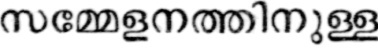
സമ്മേളനത്തിനുള്ള
